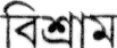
বিশ্রাম
